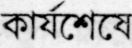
কার্যশেষে
